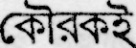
কৌরকই
